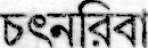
চৎনরিবা
